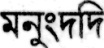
মনুংদদি
